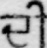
ਦੀ
